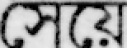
সেয়ে
